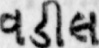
વડીલ
